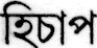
হিচাপ
